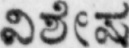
ವಿಶೇಷ
